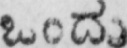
ಒಂದು
